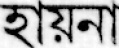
হায়না
